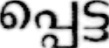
പ്പെട്ട
